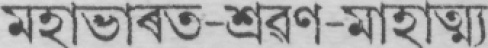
মহাভাৰত-শ্ৰৱণ-মাহাত্ম
